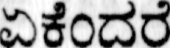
ಏಕೆಂದರೆ
